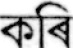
কৰি
